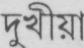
দুখীয়া
